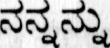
ನನ್ನನ್ನು
